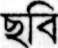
ছবি
